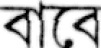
বাবে
